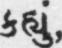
કહ્યું,
